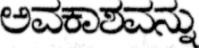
ಅವಕಾಶವನ್ನು
